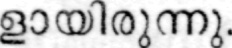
ളായിരുന്നു.
